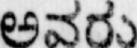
ಅವರು
